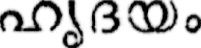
ഹൃദയം
